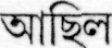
আছিল
